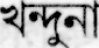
খন্দুনা
